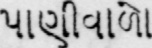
પાણીવાળો
